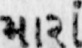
મારાં
